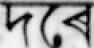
দৰে
